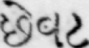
છેવટ
